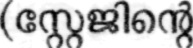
(സ്റ്റേജിന്റെ
